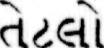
તેટલો
